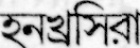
হনখ্রসিরা
